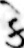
કે
